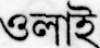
ওলাই
